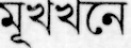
মূখখনে
